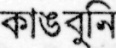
কাঙবুনি
